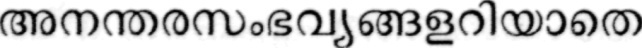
അനന്തരസംഭവ്യങ്ങളറിയാതെ
